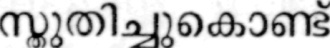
സ്തുതിച്ചുകൊണ്ട്
